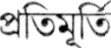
প্রতিমূর্তি
